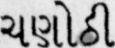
ચણોઠી
